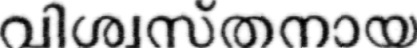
വിശ്വസ്തനായ
